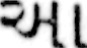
આ
